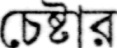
চেষ্টার
